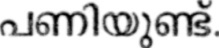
പണിയുണ്ട്.
